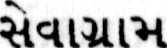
સેવાગ્રામ
